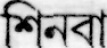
শিনবা
